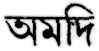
অমদি
